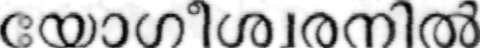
യോഗീശ്വരനില്‍
